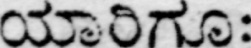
ಯಾರಿಗೂ:
